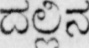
ದಲ್ಲಿನ
